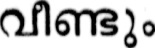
വീണ്ടും
